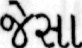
જેસા
